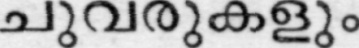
ചുവരുകളും
